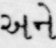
અને
